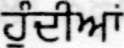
ਹੁੰਦੀਆਂ
